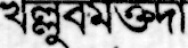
খল্লুবমক্তদা
